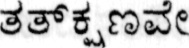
ತತ್‌ಕ್ಷಣವೇ
